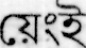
য়েংই
